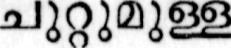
ചുറ്റുമുള്ള
